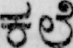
ಕಲೆ
